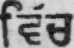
ਵਿੱਚ
